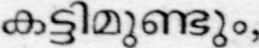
കട്ടിമുണ്ടും,
